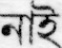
নাই
